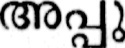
അപ്പു
